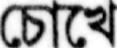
চোখে
